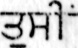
ਤੁਸੀਂ
